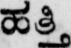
ಹತ್ತಿ
